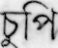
চুপি
